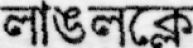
লাঙলক্লে
